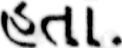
હતા.
